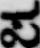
ಪ
